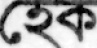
হেক
